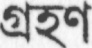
গ্রহণ
